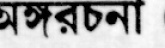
অঙ্গরচনা
